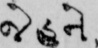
જેહને
